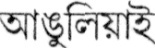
আঙুলিয়াই
